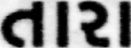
તારા
